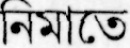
নিমাতে
